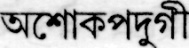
অশোকপদুগী
